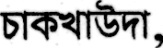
চাকখাউদা,
